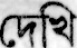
দেখি
